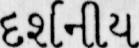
દર્શનીય
